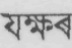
যক্ষৰ
